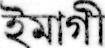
ইমাগী
